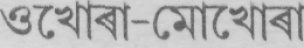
ওখোৰা-মোখোৰা
